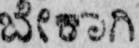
ಬೇಕಾಗಿ
